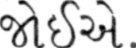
જોઈએ.
